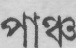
পাঞ্চ
